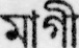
মাগী
